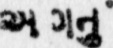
અગનું
